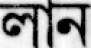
লান
